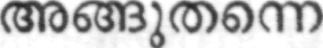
അങ്ങുതന്നെ
